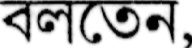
বলতেন,
